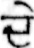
ਦੇ
